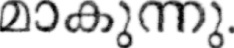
മാകുന്നു.
